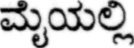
ಮೈಯಲ್ಲಿ
